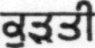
ਕੁੜਤੀ
